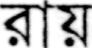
রায়
